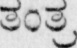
ತಂತ್ರ
